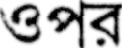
ওপর
